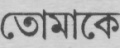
তোমাকে
